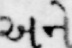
અને
